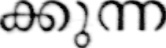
ക്കുന്ന
